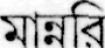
মান্নরি
